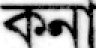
কনা
